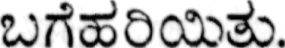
ಬಗೆಹರಿಯಿತು.
